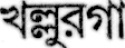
খল্লরগা
